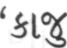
'કાજુ
